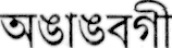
অঙাঙবগী
